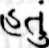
હતું
